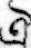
ঐ
